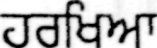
ਹਰਖਿਆ
